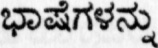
ಭಾಷೆಗಳನ್ನು
